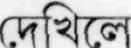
দেখিলে
